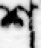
শ
